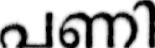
പണി
